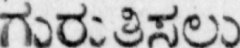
ಗುರುತಿಸಲು
